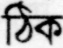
ঠিক
